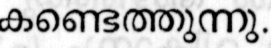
കണ്ടെത്തുന്നു.
